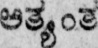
ಅತ್ಯಂತ
